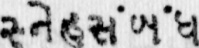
સ્નેહસંબંધ
